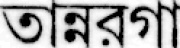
তান্নরগা
